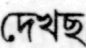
দেখছ
